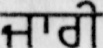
ਜਾਰੀ
